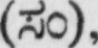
(ಸಂ),
